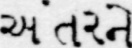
અંતરને
